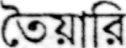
তৈয়ারি
